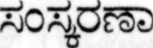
ಸಂಸ್ಕರಣಾ
